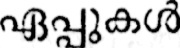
ഏപ്പുകള്‍
